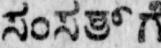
ಸಂಸತ್‌ಗೆ
